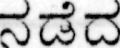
ನಡೆದ
